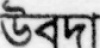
উবদা
